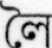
লৈ
